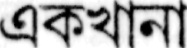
একখানা
